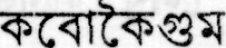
কবোকৈগুম
